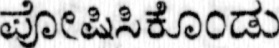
ಪೋಷಿಸಿಕೊಂಡು
